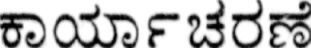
ಕಾರ್ಯಾಚರಣೆ
